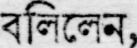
বলিলেন,
